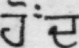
ਹੋਂਦ
